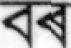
বৰ
